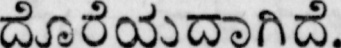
ದೊರೆಯದಾಗಿದೆ.
